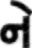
ને
